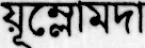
য়ূম্লোমদা
